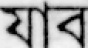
যাব
